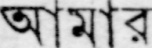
আমার
